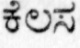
ಕೆಲಸ
